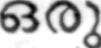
ഒരു
